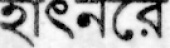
হাৎনরে
